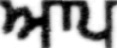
ਆਪ
